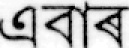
এবাৰ
